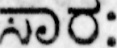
ಸಾರ:
